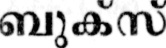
ബുക്സ്
